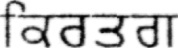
ਕਿਰਤਗ
